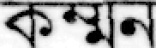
কম্মন
